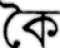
কৈ
